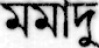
মমাদু
